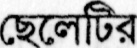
ছেলেটির
